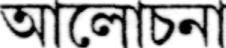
আলোচনা
